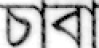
চাবা
